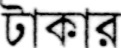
টাকার
